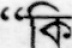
"কি
